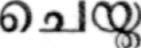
ചെയ്ത
